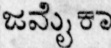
ಜಮೈಕಾ
